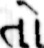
તો
